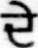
ਦੇ
